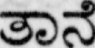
ತಾನೆ
